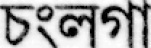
চংলগা
